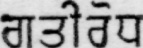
ਗਤੀਰੋਧ
